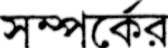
সম্পর্কের
